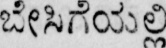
ಬೇಸಿಗೆಯಲ್ಲಿ
